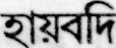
হায়বদি
